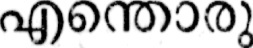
എന്തൊരു
